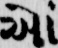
ઓં
